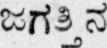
ಜಗತ್ತಿನ
